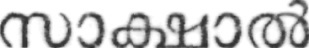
സാക്ഷാല്‍
